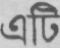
এটি
